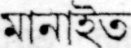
মানাইত
